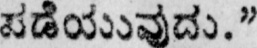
ಪಡೆಯುವುದು.”
